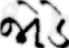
જોડે
